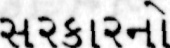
સરકારનો
